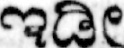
ಇಡೀ
